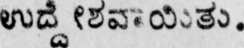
ಉದ್ದೇಶವಾಯಿತು.
